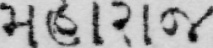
મહારાજ
